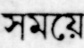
সময়ে
